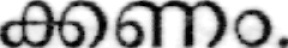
ക്കണം.
